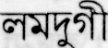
লমদুগী
